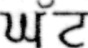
ਘੱਟ
